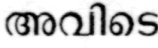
അവിടെ
